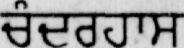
ਚੰਦਰਹਾਸ
